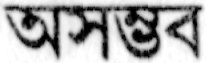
অসম্ভব
